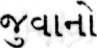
જુવાનો
